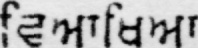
ਵਿਆਖਿਆ
